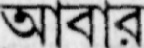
আবার
